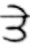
ਤੇ
